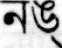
নঙ্
